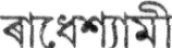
ৰাধেশ্যামী
